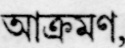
আক্রমণ,
